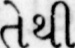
તેથી
